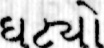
ઘટ્યો
